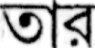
তার
